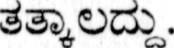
ತತ್ಕಾಲದ್ದು.
